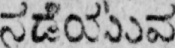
ನಡೆಯುವ
